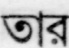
তার
